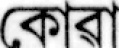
কোৱা
